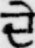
ਦੇ
